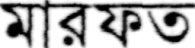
মারফত
